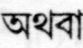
অথবা
